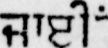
ਜਾਈਂ
